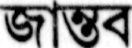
জান্তব
